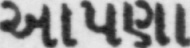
આપણા
